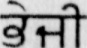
ਭੇਜੀ
